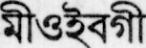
মীওইবগী
